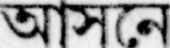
আসনে
